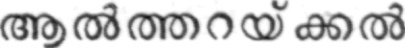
ആല്‍ത്തറയ്ക്കല്‍
